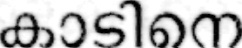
കാടിനെ
